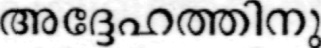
അദ്ദേഹത്തിനു
